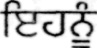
ਇਹਨੂੰ
